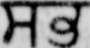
ਸਭ
